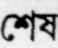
শেষ
